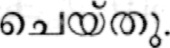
ചെയ്തു.
